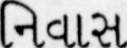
નિવાસ
